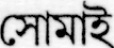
সোমাই
